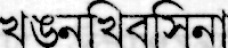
খঙনখিবসিনা
